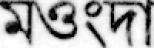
মওংদা
